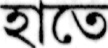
হাতে
